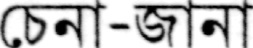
চেনা-জানা
